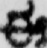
ಈ
